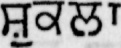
ਸ਼ੁਕਲਾ
